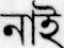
নাই
